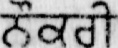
ਨੌਕਰੀ
